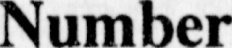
Number
